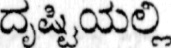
ದೃಷ್ಟಿಯಲ್ಲಿ
